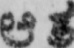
ಆತ
